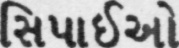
સિપાઈઓ
